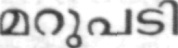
മറുപടി
